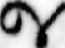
જ
